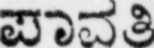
ಪಾವತಿ
